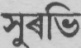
সুৰভি
